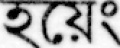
হয়েং
